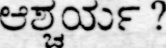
ಆಶ್ಚರ್ಯ?
